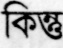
কিন্তু
